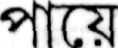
পায়ে
